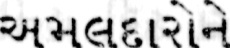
અમલદારોને
